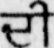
ਦੀ
